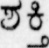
ಶಕ್ತಿ
